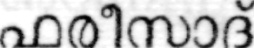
ഫരീസാദ്
